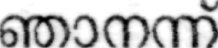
ഞാനന്ന്
